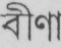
বীণা
